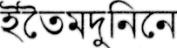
ইতৈমদুনিনে
